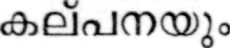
കല്പനയും
